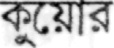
কুয়োর
